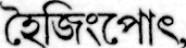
হৈজিংপোৎ,
